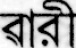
ৱারী
